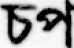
চপ
